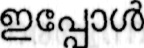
ഇപ്പോള്‍
